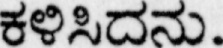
ಕಳಿಸಿದನು.
